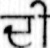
ਦੀ
